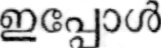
ഇപ്പോള്‍
